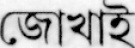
জোখাই
